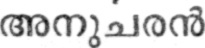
അനുചരന്‍
